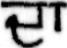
ਦਾ
